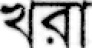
খরা
